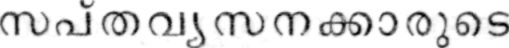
സപ്തവ്യസനക്കാരുടെ
